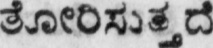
ತೋರಿಸುತ್ತದೆ
